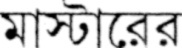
মাস্টারের
